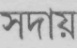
সদায়
